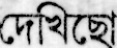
দেখিছো
